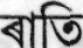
ৰাতি
